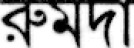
রুমদা
